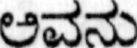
ಅವನು
